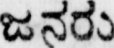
ಜನರು
